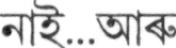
নাই...আৰু
